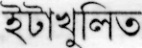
ইটাখুলিত
